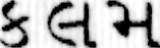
કલમ
